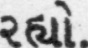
રહ્યો.
